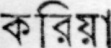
করিয়া
